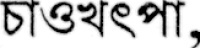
চাওখৎ‍পা,
